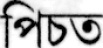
পিচত
